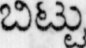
ಬಿಟ್ಟು
